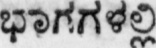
ಭಾಗಗಳಲ್ಲಿ
